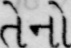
તેનો
